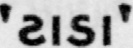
'ટાડા'
